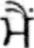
ਮੈਂ
